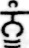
ਨੂੰ
